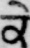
ਕੇ
